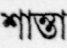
শান্তা
